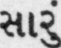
સારું
